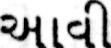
આવી
